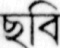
ছবি
